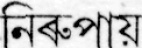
নিৰুপায়
